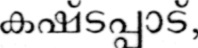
കഷ്ടപ്പാട്,
